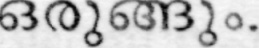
ഒരുങ്ങും.
